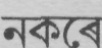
নকৰে
